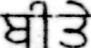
ਬੀਤੇ
